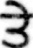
ਤੇ
